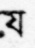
যে
